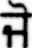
ਜੋ
